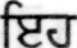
ਇਹ
